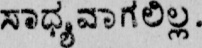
ಸಾಧ್ಯವಾಗಲಿಲ್ಲ.
